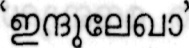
'ഇന്ദുലേഖാ'
